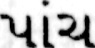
પાંચ
